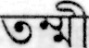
তম্মী
